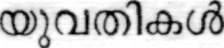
യുവതികള്‍
